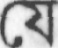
যে
